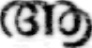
ആ
